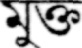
মুক্ত
